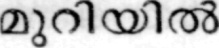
മുറിയില്‍
